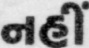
નહીં
